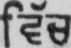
ਵਿੱਚ
